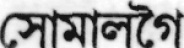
সোমালগৈ
